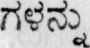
ಗಳನ್ನು
